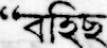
"বহিছ
